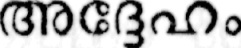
അദ്ദേഹം
